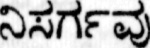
ನಿಸರ್ಗವು
